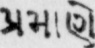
પ્રમાણે
